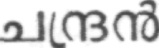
ചന്ദ്രന്‍
